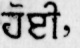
ਹੋਈ,
